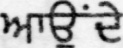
ਆਉਂਦੇ
